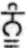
ਨੂੰ
